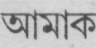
আমাক
